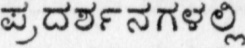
ಪ್ರದರ್ಶನಗಳಲ್ಲಿ
